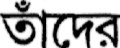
তাঁদের
